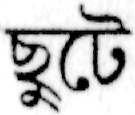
ছুটে
